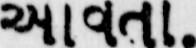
આવતા.
